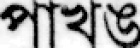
পাখঙ
